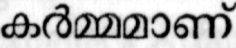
കര്‍മ്മമാണ്
